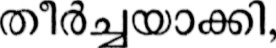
തീര്‍ച്ചയാക്കി,
